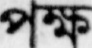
পক্ষ
